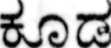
ಕೂಡ
